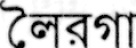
লৈরগা
